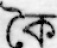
কৈ
